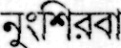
নুংশিরবা
